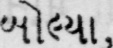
બોલ્યા,
